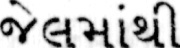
જેલમાંથી
